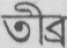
তীব্ৰ
